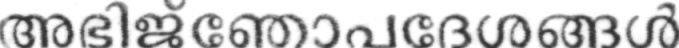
അഭിജ്ഞോപദേശങ്ങള്‍
